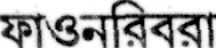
ফাওনরিবরা
